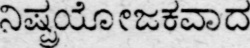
ನಿಷ್ಪ್ರಯೋಜಕವಾದ
